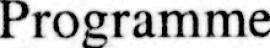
Programme
